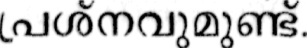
പ്രശ്നവുമുണ്ട്.
